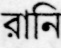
রানি
